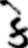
કે
